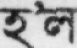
হ'ল
